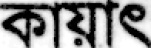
কায়াৎ
